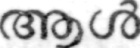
ആള്‍
